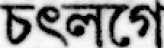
চৎলগে
